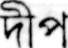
দীপ
